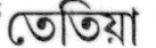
তেতিয়া
